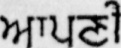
ਆਪਣੀ
